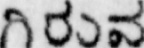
ಗಿರುವ
